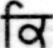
ਕਿ
